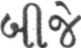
બીજે
